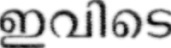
ഇവിടെ
